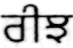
ਰੀਝ
